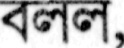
বলল,
